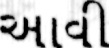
આવી
